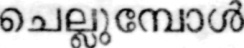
ചെല്ലുമ്പോള്‍
